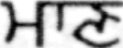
ਮਾਣ
